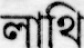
লাথি
